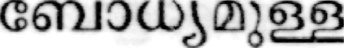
ബോധ്യമുള്ള
